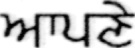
ਆਪਣੇ
